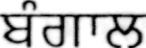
ਬੰਗਾਲ
